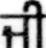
ਜੀ
